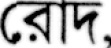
রোদ,
